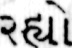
રહ્યો
